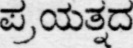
ಪ್ರಯತ್ನದ
